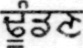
ਢੂੰਡਣ
